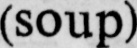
(soup)
